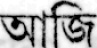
আজি
